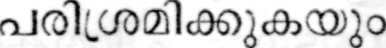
പരിശ്രമിക്കുകയും
